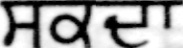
ਸਕਦਾ
